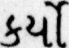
કર્યો
